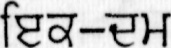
ਇਕ-ਦਮ
